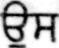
ਉਸ
